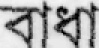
বাধা
